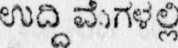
ಉದ್ದಿಮೆಗಳಲ್ಲಿ
